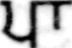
ਪਾ
